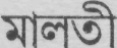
মালতী
